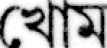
খোম
